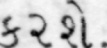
કરશે.
